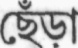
ছেঁড়া
